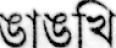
ঙাঙখি
